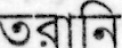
তরানি
